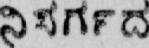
ನಿಸರ್ಗದ
